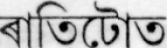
ৰাতিটোত
